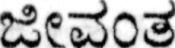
ಜೀವಂತ
